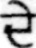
ਦੇ
